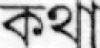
কথা
